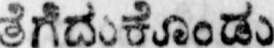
ತೆಗೆದುಕೊಂಡು
